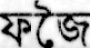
ফজৈ
